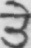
ਤੇ
